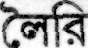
লৈরি
